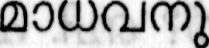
മാധവനു
